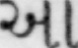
આ
